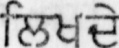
ਲਿਖਦੇ
